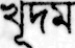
খূদম
